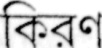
কিরণ
